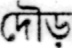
দৌড়
